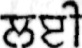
ਲਈ
